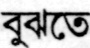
বুঝতে
